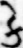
કે
